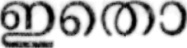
ഇതൊ
